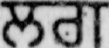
ਲਗ
